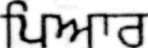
ਪਿਆਰ
